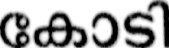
കോടി
